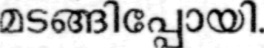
മടങ്ങിപ്പോയി.
